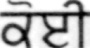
ਕੋਈ
